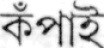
কঁপাই
